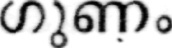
ഗുണം
